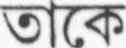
তাকে
